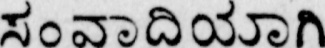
ಸಂವಾದಿಯಾಗಿ
